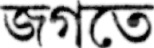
জগতে
